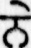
ਨੇ
